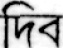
দিব
